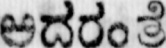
ಅದರಂತೆ
